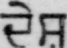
ਦੇਸ਼
